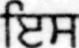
ਇਸ
